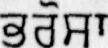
ਭਰੋਸਾ
